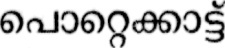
പൊറ്റെക്കാട്ട്
